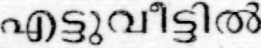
എട്ടുവീട്ടില്‍
